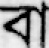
বা
